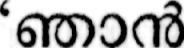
'ഞാന്‍
